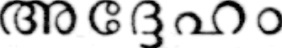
അദ്ദേഹം
